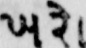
ખરો
